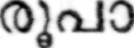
രൂപാ
